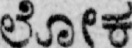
ಲೋಕ
